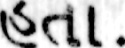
હતા.
